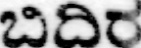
ಬಿದಿರ
